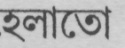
হেলাতো
